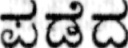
ಪಡೆದ
